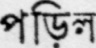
পড়িল
